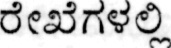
ರೇಖೆಗಳಲ್ಲಿ
